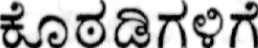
ಕೊಠಡಿಗಳಿಗೆ
